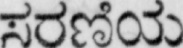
ಸರಣಿಯ
